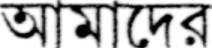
আমাদের
